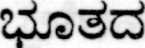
ಭೂತದ
